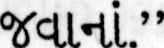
જવાનાં."
